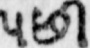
પછી
